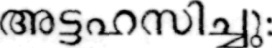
അട്ടഹസിച്ചു:
